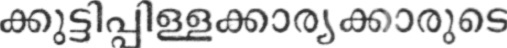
ക്കുട്ടിപ്പിള്ളക്കാര്യക്കാരുടെ
